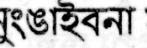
নুংঙাইবনা
